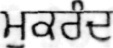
ਮੁਕਰੰਦ
